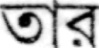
তার
